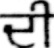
ਦੀ
